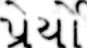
પ્રેર્યો
